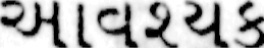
આવશ્યક
